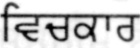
ਵਿਚਕਾਰ
